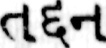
તદ્દન
